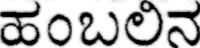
ಹಂಬಲಿನ
